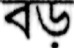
বড়
